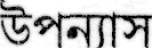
উপন্যাস
